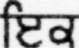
ਇਕ
